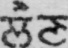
ਲੈਣ
